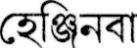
হেঞ্জিনবা
